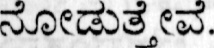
ನೋಡುತ್ತೇವೆ.
